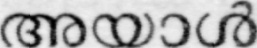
അയാള്‍
